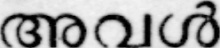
അവള്‍
